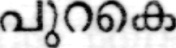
പുറകെ
